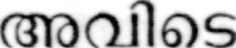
അവിടെ
